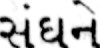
સંઘને
